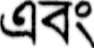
এবং
